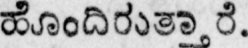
ಹೊಂದಿರುತ್ತಾರೆ.
